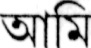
আমি
